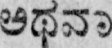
ಅಥವಾ
